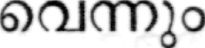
വെന്നും
